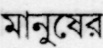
মানুষের
